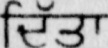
ਦਿੱਤਾ
